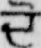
ਦੋ
